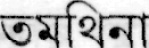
তমথিনা
